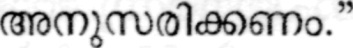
അനുസരിക്കണം.”
